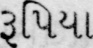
રૂપિયા
